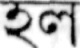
হল
